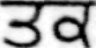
ਤਕ
